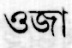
ওজা
